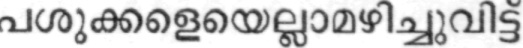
പശുക്കളെയെല്ലാമഴിച്ചുവിട്ട്
